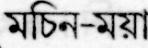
মচিন-ময়া
